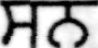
ਸਨ
